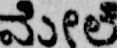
ಮೇಲೆ
